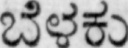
ಬೆಳಕು
